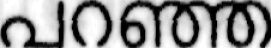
പറഞ്ഞ
